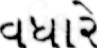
વધારે
